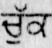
ਚੁੱਕ
